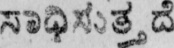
ಸಾಧಿಸುತ್ತದೆ.
